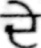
ਦੇ
